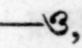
–ও,
